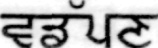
ਵਡੱਪਣ
